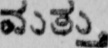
ಮತ್ತು
